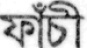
ফাঁচী
